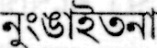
নুংঙাইতনা
